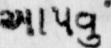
આપવું
